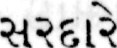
સરદારે
